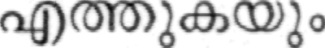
എത്തുകയും
